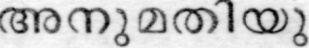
അനുമതിയു
